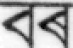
বৰ
